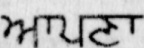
ਆਪਣਾ
